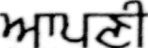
ਆਪਣੀ
